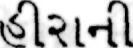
હીરાની
